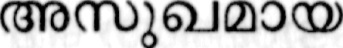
അസുഖമായ
